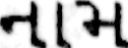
નામ
